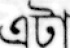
এটা
